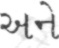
અને
